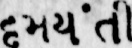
દમયંતી
